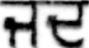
ਜਦ
